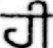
ਹੀ
